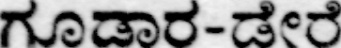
ಗೂಡಾರ-ಡೇರೆ
